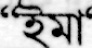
“ইমা‘
